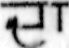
ਦਾ
